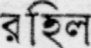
রহিল
